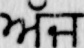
ਅੱਜ
